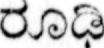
ರೂಢಿ
